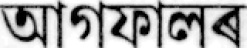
আগফালৰ
